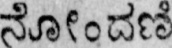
ನೋಂದಣೆ
